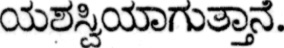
ಯಶಸ್ವಿಯಾಗುತ್ತಾನೆ.
